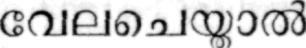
വേലചെയ്താല്‍
